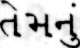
તેમનું
